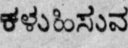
ಕಳುಹಿಸುವ
